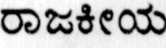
ರಾಜಕೀಯ
